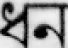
ধন
